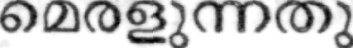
മെരളുന്നതു
